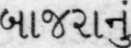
બાજરાનું
